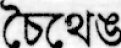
চৈথেঙ
